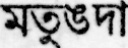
মতুঙদা
